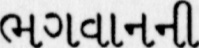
ભગવાનની
